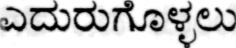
ಎದುರುಗೊಳ್ಳಲು
